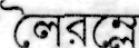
লৈরম্লে
